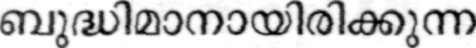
ബുദ്ധിമാനായിരിക്കുന്ന
